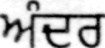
ਅੰਦਰ
